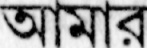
আমার
